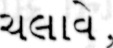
ચલાવે,
